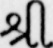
શ્રી
